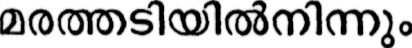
മരത്തടിയില്‍നിന്നും
